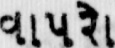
વાપરો
